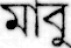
মাবু
